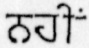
ਨਹੀਂ
